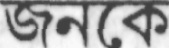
জনকে
